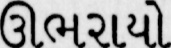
ઊભરાયો
